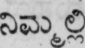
ನಿಮ್ಮಲ್ಲಿ
